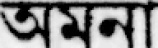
অমনা
